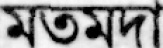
মতমদা
